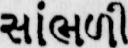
સાંભળી
